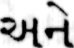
અને
